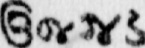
ઉજ્જડ
